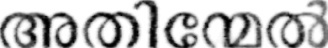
അതിന്മേല്‍
